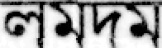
লমদম
